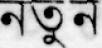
নতুন
